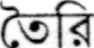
তৈরি
